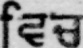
ਵਿਚ
